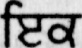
ਇਕ
